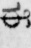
ಈ
